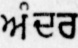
ਅੰਦਰ
